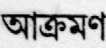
আক্রমণ
